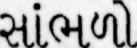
સાંભળો
